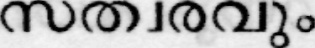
സത്വരവും
